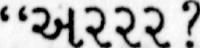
"અરરર?
